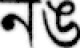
নঙ
